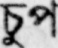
চুপ
